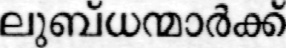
ലുബ്ധന്മാര്‍ക്ക്
